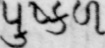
પુષ્કળ
